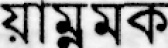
য়াম্নমক
